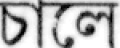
চালে
